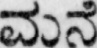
ಮನೆ
